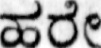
ಹರೇ
